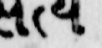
સત્ય
